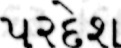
પરદેશ
